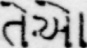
તેઓ
